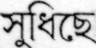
সুধিছে
